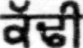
ਕੱਢੀ
